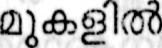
മുകളില്‍
